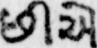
છીએ
